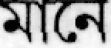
মানে
